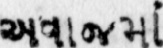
અવાજમાં
